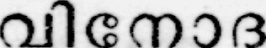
വിനോദ
